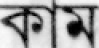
কাম
